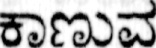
ಕಾಣುವ
